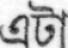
এটা
